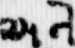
અને
